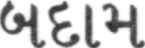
બદામ
